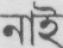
নাই
